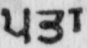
ਪਤਾ
